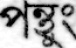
পন্থুং
